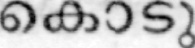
കൊടു
